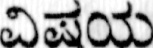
ವಿಷಯ
